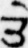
ਤੇ
